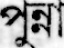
পুন্না
